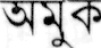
অমুক
